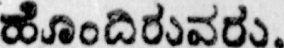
ಹೊಂದಿರುವರು.
